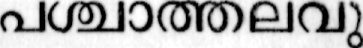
പശ്ചാത്തലവു
